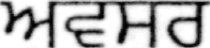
ਅਵਸਰ
